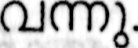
വന്നു.
